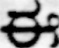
ಈ
